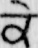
ਕੇ
